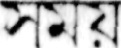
সময়
